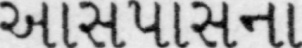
આસપાસના
